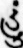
હું
